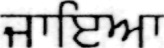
ਜਾਇਆ
